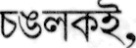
চঙলকই,
